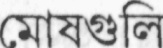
মোষগুলি
